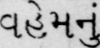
વહેમનું
